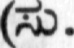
(ಸು.
